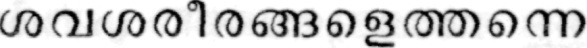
ശവശരീരങ്ങളെത്തന്നെ
